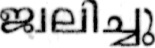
ജ്വലിച്ചു
